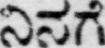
ನಿನಗೆ
